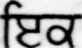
ਇਕ
